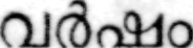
വര്‍ഷം
